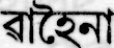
ৱাহৈনা
